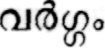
വര്‍ഗ്ഗം
